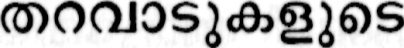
തറവാടുകളുടെ
